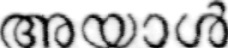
അയാള്‍
